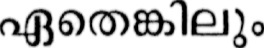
ഏതെങ്കിലും
